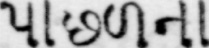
પાછળના
